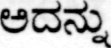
ಅದನ್ನು
